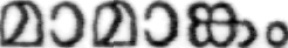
മാമാങ്കം
